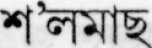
শ'লমাছ
